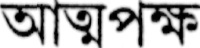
আত্মপক্ষ
